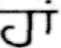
ਹਾਂ
